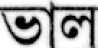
ভাল
